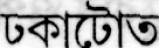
ঢকাটোত
